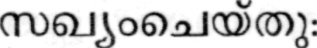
സഖ്യംചെയ്തു:
